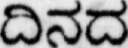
ದಿನದ
